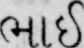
ભાઈ
